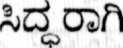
ಸಿದ್ಧರಾಗಿ
